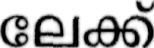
ലേക്ക്
